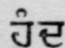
ਹੁੰਦ
